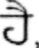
ਹੈ,
